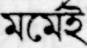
মর্মেই
